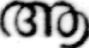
ആ
